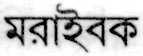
মরাইবক
